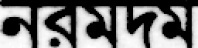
নরমদম
